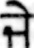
ਜੇ
